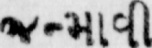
જન્માવી
